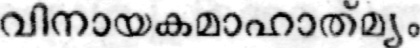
വിനായകമാഹാത് മ്യം
